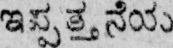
ಇಪ್ಪತ್ತನೆಯ
